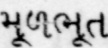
મૂળભૂત
